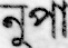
নুপা
